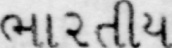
ભારતીય
